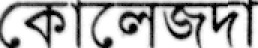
কোলেজদা
